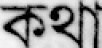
কথা
